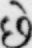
છે
